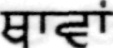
ਥਾਵਾਂ
